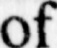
of
